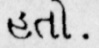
હતો.
